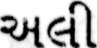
અલી
